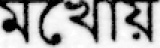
মখোয়
